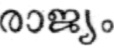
രാജ്യം
